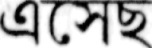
এসেছ
